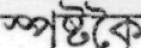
স্পষ্টকৈ
